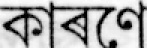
কাৰণে
